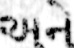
અને
